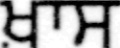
ਖ਼ਾਸ
